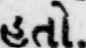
હતો.
